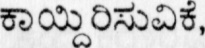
ಕಾಯ್ದಿರಿಸುವಿಕೆ,
